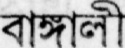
বাঙ্গালী
